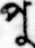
পু
